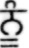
ਨੂੰ
